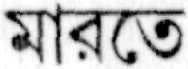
মারতে
